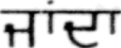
ਜਾਂਦਾ
